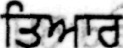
ਤਿਆਰ
